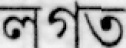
লগত
